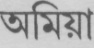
অমিয়া
